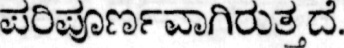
ಪರಿಪೂರ್ಣವಾಗಿರುತ್ತದೆ.
